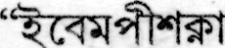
“ইবেমপীশক্না
